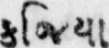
કજિયા
